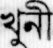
খুনী
